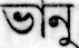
ভানু
